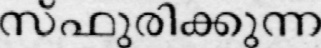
സ്ഫുരിക്കുന്ന
